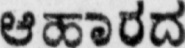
ಆಹಾರದ
